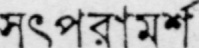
সৎপরামর্শ
